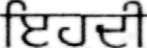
ਇਹਦੀ
